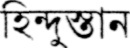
হিন্দুস্তান
